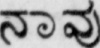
ನಾವು
